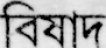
বিষাদ
